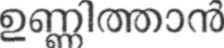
ഉണ്ണിത്താന്‍
